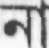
না
